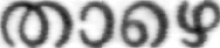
താഴെ
